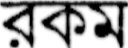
রকম
